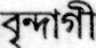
বৃন্দাগী
